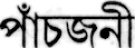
পাঁচজনী
